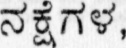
ನಕ್ಷೆಗಳ,
